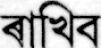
ৰাখিব
